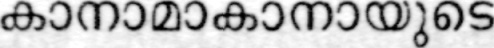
കാനാമാകാനായുടെ
